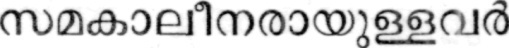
സമകാലീനരായുള്ളവര്‍
